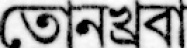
তোনখ্রবা
